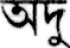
অদু
